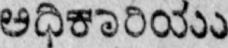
ಅಧಿಕಾರಿಯು
